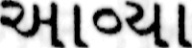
આવ્યા
